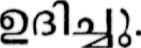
ഉദിച്ചു.
